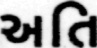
અતિ
